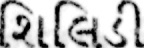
શિલિડી
